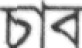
চাব
